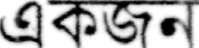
একজন
